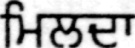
ਮਿਲਦਾ
